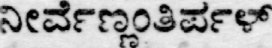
ನೀರ್ವೆಣ್ಣ೦ತಿರ್ಪಳ್
